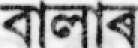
বালাৰ
